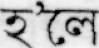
হ'লে
